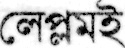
লেপ্লমই
